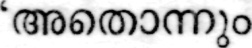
‘അതൊന്നും
